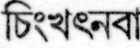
চিংখৎনবা
